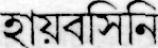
হায়বসিনি
